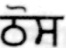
ਠੋਸ
